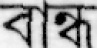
বান্ধ
